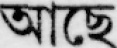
আছে
